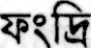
ফংদ্রি
